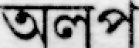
অলপ
